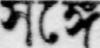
সঙ্গে
